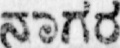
ನಾಗರ
